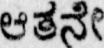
ಆತನೇ
